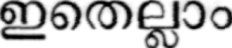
ഇതെല്ലാം
